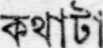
কথাটা
